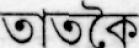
তাতকৈ
